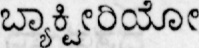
ಬ್ಯಾಕ್ಟೀರಿಯೋ
